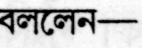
বললেন–
